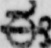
ಈ
